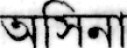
অসিনা
